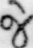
જે
